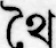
থৈ
